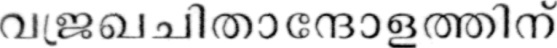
വജ്രഖചിതാന്ദോളത്തിന്
